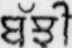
ਬੱਝੀ
